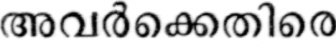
അവര്‍ക്കെതിരെ
